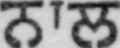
ਨਾਲ
